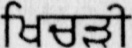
ਖਿਚੜੀ
